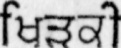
ਖਿੜਕੀ
